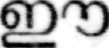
ഈ
